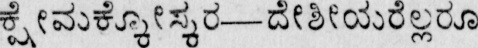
ಕ್ಷೇಮಕ್ಕೋಸ್ಕರ-ದೇಶೀಯರೆಲ್ಲರೂ
